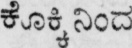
ಕೊಕ್ಕಿನಿಂದ
